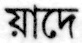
য়াদে
